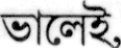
ভালেই,
